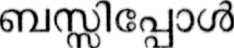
ബസ്സിപ്പോള്‍
